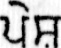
ਪੇਸ਼
